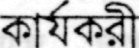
কার্যকরী
